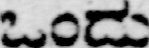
ಒಂದು
